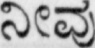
ನೀವು
